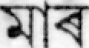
মাৰ
